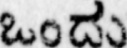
ಒಂದು
